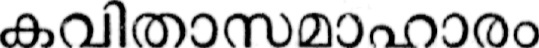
കവിതാസമാഹാരം
